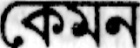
কেমন
